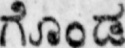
ಗೊಂಡ
